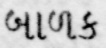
બાળક
